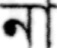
না
